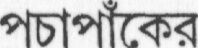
পচাপাঁকের
